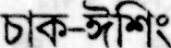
চাক-ঈশিং
